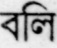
বলি
